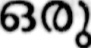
ഒരു
